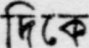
দিকে
